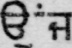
ਉਂਜ
